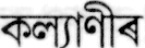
কল্যাণীৰ
